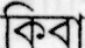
কিবা
